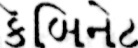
કૅબિનેટ
